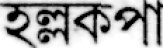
হল্লকপা
